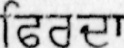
ਫਿਰਦਾ
